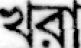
খরা
